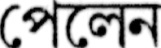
পেলেন
